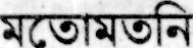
মতোমতনি
